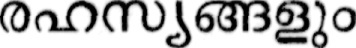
രഹസ്യങ്ങളും
